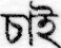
চাই
